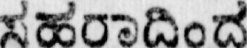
ಸಹರಾದಿಂದ
